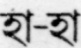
হা-হা
